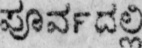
ಪೂರ್ವದಲ್ಲಿ
